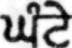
ਘੰਟੇ
